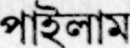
পাইলাম
